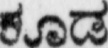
ಕೂಡ
